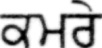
ਕਮਰੇ
